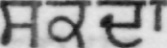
ਸਕਦਾ
